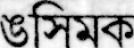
ঙসিমক
